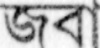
জবা
